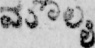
ಮೌಲ್ಯ
